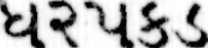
ધરપકડ
